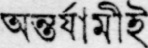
অন্তর্যামীই
